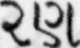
રણ
